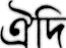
ঐদি
